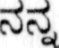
ನನ್ನ
